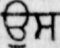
ਉਸ
